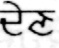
ਦੇਣ
